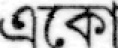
একো
